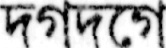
দগদগে
